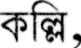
কল্লি,
